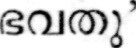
ഭവതു'
